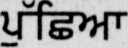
ਪੁੱਛਿਆ
